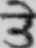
ਤੇ
